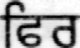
ਫਿਰ
